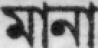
মানা
